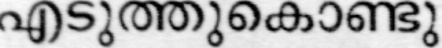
എടുത്തുകൊണ്ടു
